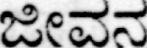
ಜೀವನ
